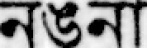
নঙনা
